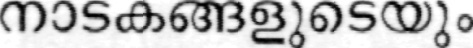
നാടകങ്ങളുടെയും
